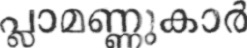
പ്ലാമണ്ണുകാര്‍
